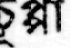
চূপ্পা
